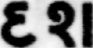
દશ
